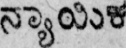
ನ್ಯಾಯಿಕ
